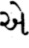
એ
